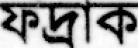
ফদ্রাক
